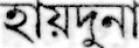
হায়দুনা
